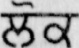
ਲੋਕ
